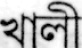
খালী
